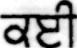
ਕਈ
